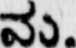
ಮ.
